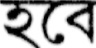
হবে
